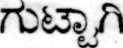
ಗುಟ್ಟಾಗಿ
